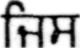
ਜਿਸ
